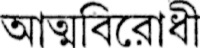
আত্মবিরোধী
